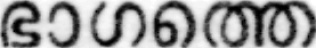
ഭാഗത്തെ
